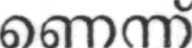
ണെന്ന്
